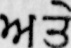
ਅਤੇ
